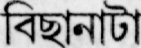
বিছানাটা
